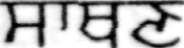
ਸਾਥਣ
